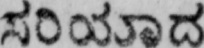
ಸರಿಯಾದ
